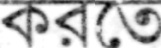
করতে
